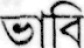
ভাবি
